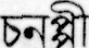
চনপ্পী
